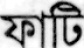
ফাটি
